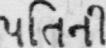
પતિની
